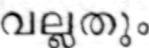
വല്ലതും
